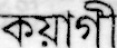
কয়াগী
